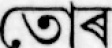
তোৰ
